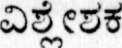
ವಿಶ್ಲೇಶಕ
